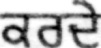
ਕਰਦੇ
